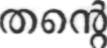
തന്റെ
